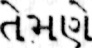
તેમણે
